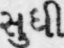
સુધી
